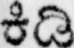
ಕಿಡಿ
